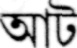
আট
